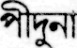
পীদুনা
